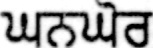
ਘਨਘੋਰ
